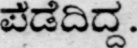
ಪೆಡೆದಿದ್ದ.
